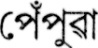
পেঁপুৱা
